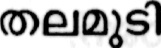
തലമുടി
